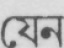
যেন
